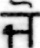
ਜੋ
